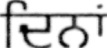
ਦਿਨਾਂ
